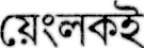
য়েংলকই
